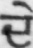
ਦੇ
